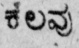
ಕೆಲವು
